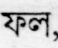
ফল,
